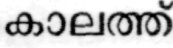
കാലത്ത്
